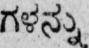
ಗಳನ್ನು
